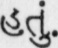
હતું.
